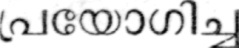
പ്രയോഗിച്ച
